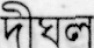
দীঘল
